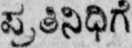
ಪ್ರತಿನಿಧಿಗೆ
